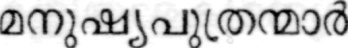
മനുഷ്യപുത്രന്മാര്‍
